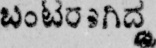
ಬಂಟರಾಗಿದ್ದ
